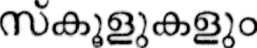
സ്കൂളുകളും
